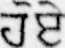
ਹੋਏ
